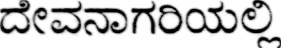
ದೇವನಾಗರಿಯಲ್ಲಿ
